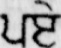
ਪਏ
